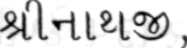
શ્રીનાથજી,
